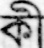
কী
